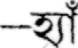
-হ্যাঁ
